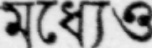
মধ্যেও
